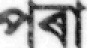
পৰা
